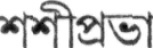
শশীপ্রভা
